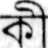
কী
